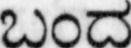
ಬಂದ
